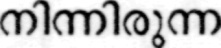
നിന്നിരുന്ന
